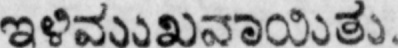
ಇಳಿಮುಖವಾಯಿತು.
